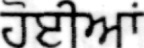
ਹੋਈਆਂ
